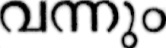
വന്നും
